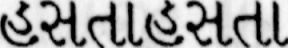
હસતાહસતા
